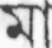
মা
